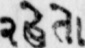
રહેતો
